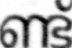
ണ്ട്
